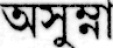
অসুম্না
